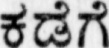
ಕಡೆಗೆ
